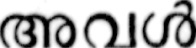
അവള്‍
